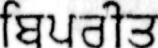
ਬਿਪਰੀਤ
